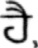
ਹੈ,
